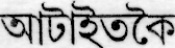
আটাইতকৈ
